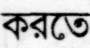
করতে
